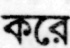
করে
